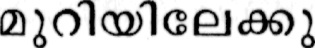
മുറിയിലേക്കു
